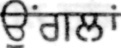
ਉਂਗਲਾਂ
